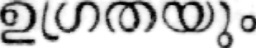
ഉഗ്രതയും
